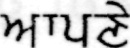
ਆਪਣੇ
